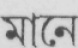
মানে
